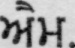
ਐਮ.
